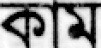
কাম
